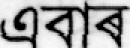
এবাৰ
